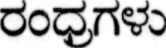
ರಂಧ್ರಗಳು
